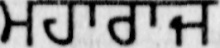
ਮਹਾਰਾਜ
